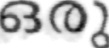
ഒരു
